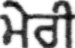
ਮੇਰੀ
